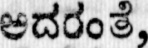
ಅದರಂತೆ,
